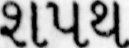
શપથ
